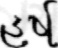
હર્ષ
